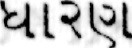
ધારણ
